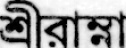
শ্রীরাম্না
